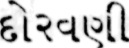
દોરવણી
